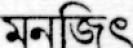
মনজিৎ
